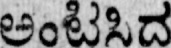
ಅಂಟಿಸಿದ
